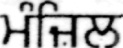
ਮੰਜ਼ਿਲ
